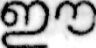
ഈ
